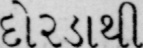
દોરડાથી
